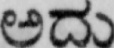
ಅದು
